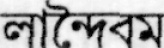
লান্দৈবম
